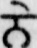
ਨੇ
